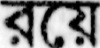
রয়ে
